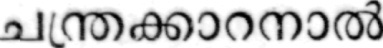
ചന്ത്രക്കാറനാല്‍
